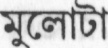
মুলোটা
